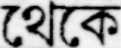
থেকে
